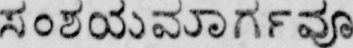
ಸಂಶಯಮಾರ್ಗವೂ
